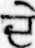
ਦੇ
